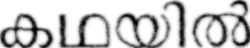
കഥയില്‍
